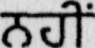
ਨਹੀਂ
